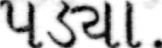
પડ્યા.
